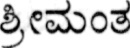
ಶ್ರೀಮಂತ
